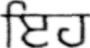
ਇਹ
